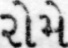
રોમે
